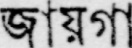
জায়গা
